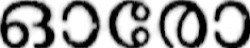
ഓരോ
